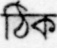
ঠিক
